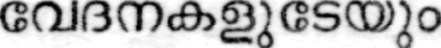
വേദനകളുടേയും
